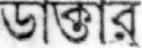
ডাক্তার
